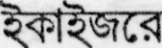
ইকাইজরে
